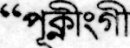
“পূক্নীংগী
